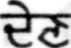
ਦੇਣ
